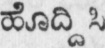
ಹೊದ್ದಿಸಿ
